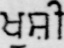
ਖੁਸ਼ੀ
